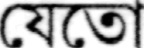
যেতো
